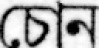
চোন
